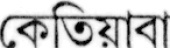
কেতিয়াবা
